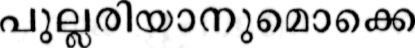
പുല്ലരിയാനുമൊക്കെ
